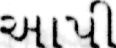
આપી
